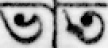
ভাত
